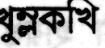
খুম্লকখি
